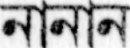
নানান
